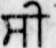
ਸੀ
